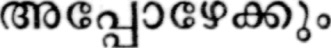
അപ്പോഴേക്കും
